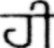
ਹੀ
